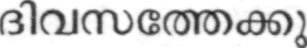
ദിവസത്തേക്കു
